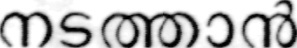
നടത്താന്‍
